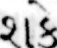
શકે
